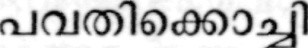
പവതിക്കൊച്ചി
